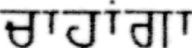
ਚਾਹਾਂਗਾ
